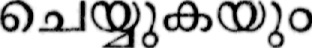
ചെയ്യുകയും
